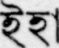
ইহা
